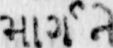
માર્ગને
